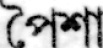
পৈশা
